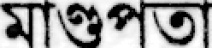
মাণ্ডপতা
